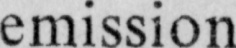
emission
